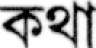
কথা
